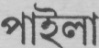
পাইলা
